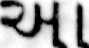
આ
